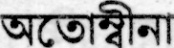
অতোম্বীনা
